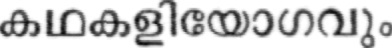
കഥകളിയോഗവും
